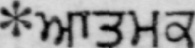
*ਆਤਮਕ
